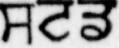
ਸਟਡ
